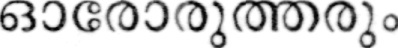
ഓരോരുത്തരും
